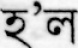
হ'ল
